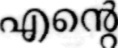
എന്റെ
